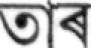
তাৰ
